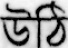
উঠি
